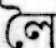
লৈ
